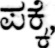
ಪಕ್ಕೆ,
